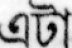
এটা
